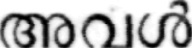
അവള്‍
